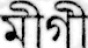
মাগী
